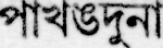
পাখঙদুনা
